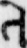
તે
